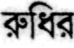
রুধির
